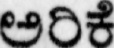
ಅರಿಕೆ
